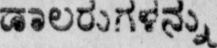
ಡಾಲರುಗಳನ್ನು
